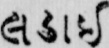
લડાઈ
